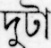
দুটা
